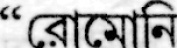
“রোমোনি
